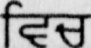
ਵਿਚ
